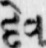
દેવ
